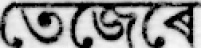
তেজেৰে
